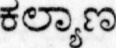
ಕಲ್ಯಾಣ
